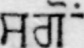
ਸਗੋਂ
